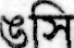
ঙসি
